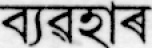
ব্যৱহাৰ
